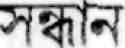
সন্ধান
